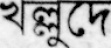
খল্লুদে
